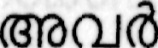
അവര്‍
